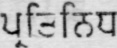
ਪ੍ਰਤਿਨਿਧ
